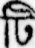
টি
